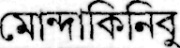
মোন্দাকিনিবু
